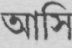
আসি
